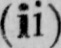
(ii)
